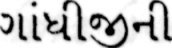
ગાંધીજીની
